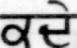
ਕਦੇ
